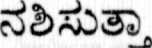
ನಶಿಸುತ್ತಾ
